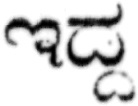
ಇದ್ದ
